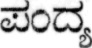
ಪಂದ್ಯ
